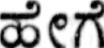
ಹೇಗೆ
